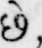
છે,
